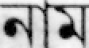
নাম
